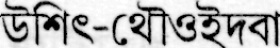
উশিৎ-থৌওইদবা
